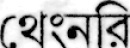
থেংনরি
